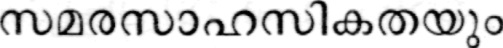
സമരസാഹസികതയും
